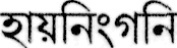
হায়নিংগনি
